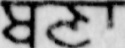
ਬਣਾ
